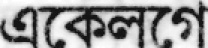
একেলগে
